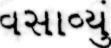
વસાવ્યું
